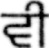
ਵੀ
